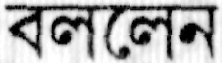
বললেন
